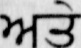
ਅਤੇ
